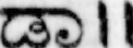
ಡಾ||
